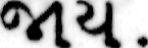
જાય.
